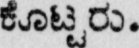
ಕೊಟ್ಟರು.
